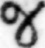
જ
